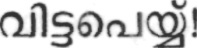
വിട്ടപെയ്യ്!
